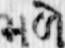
મળે
